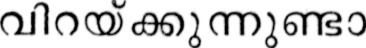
വിറയ്ക്കുന്നുണ്ടാ
